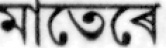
মাতেৰে
